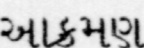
આક્રમણ
